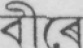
বীৰে
